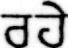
ਰਹੇ
